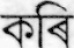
কৰি
